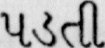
પડતી
